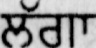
ਲੱਗਾ
